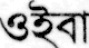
ওইবা
